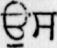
ਉਸ
